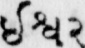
ઈશ્વર
